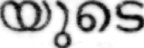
യുടെ
